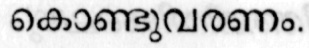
കൊണ്ടുവരണം.
